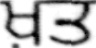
ਖ਼ਤ
